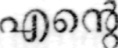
എന്റെ
